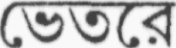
ভেতরে
